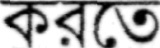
করতে
